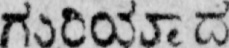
ಗುರಿಯಾದ
